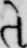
તે
